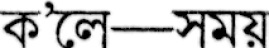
ক'লে-সময়
